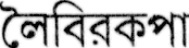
লৈবিরকপা
